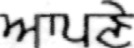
ਆਪਣੇ
